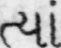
ત્યાં
